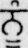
ਨੂੰ
